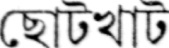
ছোটখাট
